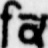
ਕਿ
